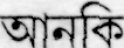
আনকি
